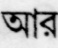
আর
